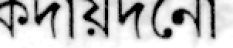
কদায়দনো
